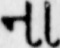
ના
